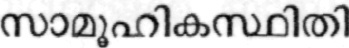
സാമൂഹികസ്ഥിതി
